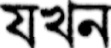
যখন
